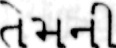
તેમની
